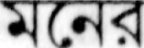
মনের
